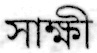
সাক্ষী
